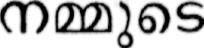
നമ്മുടെ
